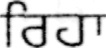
ਰਿਹਾ
